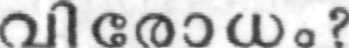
വിരോധം?
